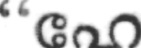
"ഹേ
